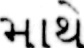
માથે
